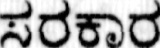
ಸರಕಾರ
